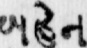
બહેન
